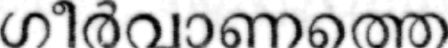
ഗീര്‍വാണത്തെ
